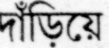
দাঁড়িয়ে
